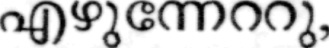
എഴുന്നേററു,
